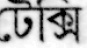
টেক্সি
